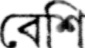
বেশি
